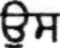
ਉਸ
